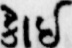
કોઈ
